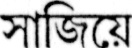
সাজিয়ে
